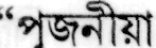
"পুজনীয়া
